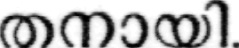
തനായി.
